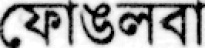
ফোঙলবা
